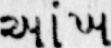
આંખ
